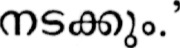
നടക്കും.’
